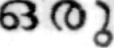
ഒരു
